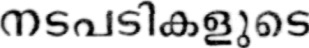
നടപടികളുടെ
